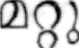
മറ്റു
